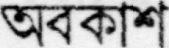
অবকাশ
